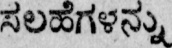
ಸಲಹೆಗಳನ್ನು
